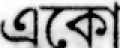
একো
